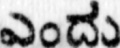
ಎಂದು
